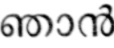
ഞാന്‍
